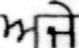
ਅਜੇ
